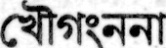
খৌগংননা
